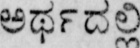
ಅರ್ಥದಲ್ಲಿ
